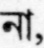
না,
